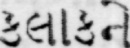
કલાકને
